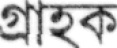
গ্রাহক
